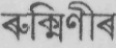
ৰুক্মিণীৰ
